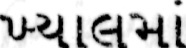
ખ્યાલમાં
